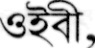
ওইবী,
